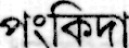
পংকিদা
